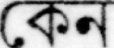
কেন
